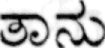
ತಾನು
